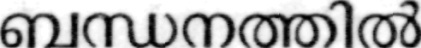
ബന്ധനത്തില്‍
